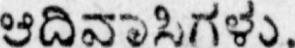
ಆದಿವಾಸಿಗಳು.
